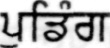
ਪੁਡਿੰਗ
